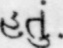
હતું.
